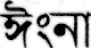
ঈংনা
